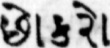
છોકરો
